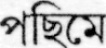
পছিমে
